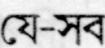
যে-সব
